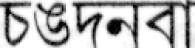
চঙদনবা
